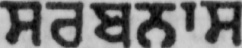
ਸਰਬਨਾਸ
